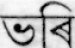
ভৰি
